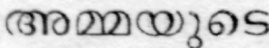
അമ്മയുടെ
